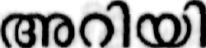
അറിയി
